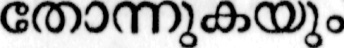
തോന്നുകയും
